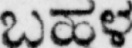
ಬಹಳ
